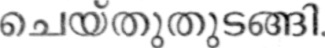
ചെയ്തുതുടങ്ങി.
